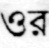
ওর
